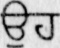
ਉਹ
